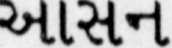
આસન
